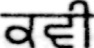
ਕਵੀ
